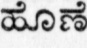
ಹೊಣೆ
